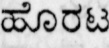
ಹೊರಟ
